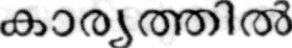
കാര്യത്തില്‍
